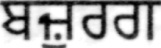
ਬਜ਼ੁਰਗ
